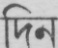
দিন
